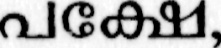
പക്ഷേ,
